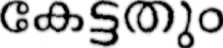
കേട്ടതും
